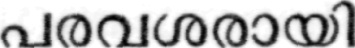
പരവശരായി
